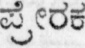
ಪ್ರೇರಕ
